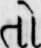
તો
